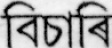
বিচাৰি
